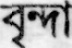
বৃন্দা
